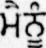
ਮੈਨੂੰ
